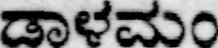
ಡಾಳಮಂ
